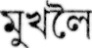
মুখলৈ
